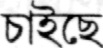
চাইছে
